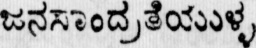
ಜನಸಾಂದ್ರತೆಯುಳ್ಳ
